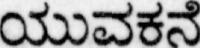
ಯುವಕನೆ
